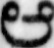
ಆ
